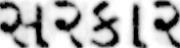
સરકાર
